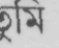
তুমি
